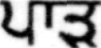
ਪਾੜ
